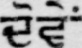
ਦੋਵੇਂ
